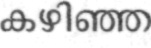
കഴിഞ്ഞ
